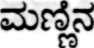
ಮಣ್ಣಿನ
